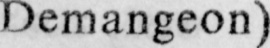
Demangeon)
